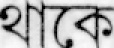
থাকে
